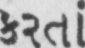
કરતાં
